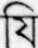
যি
